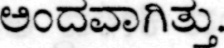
ಅಂದವಾಗಿತ್ತು.
